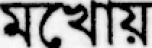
মখোয়
